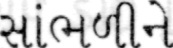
સાંભળીને
